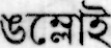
ঙম্লোই
